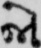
જો
